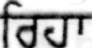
ਰਿਹਾ
